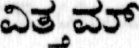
ವಿತ್ತಮ್
